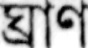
ঘ্রাণ
